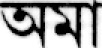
অমা
